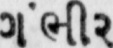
ગંભીર
